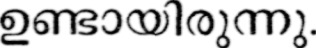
ഉണ്ടായിരുന്നു.
